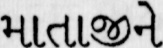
માતાજીને
